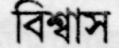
বিশ্বাস
